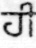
ਹੀ
